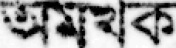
অমখক
